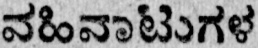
ವಹಿವಾಟುಗಳ
